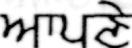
ਆਪਣੇ
